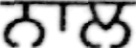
ਨਾਲ
